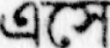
এসে
